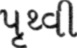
પૃથ્વી
